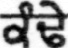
ਕੰਢੇ
